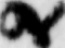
જ
